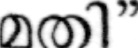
മതി”
